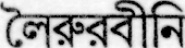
লৈরুরবীনি
